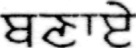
ਬਣਾਏ।
